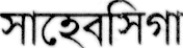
সাহেবসিগা
